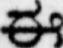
ಈ
